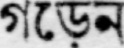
গড়েন
